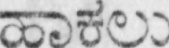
ಹಾಕಲು
